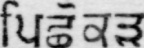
ਪਿਛੋਕੜ
